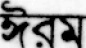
ঈরম
